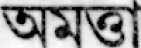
অমত্তা
